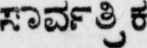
ಸಾರ್ವತ್ರಿಕ
